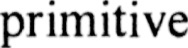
primitive
